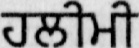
ਹਲੀਮੀ
